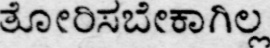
ತೋರಿಸಬೇಕಾಗಿಲ್ಲ
